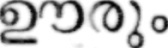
ഊരും
